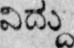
ವಿದ್ದು
